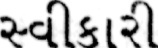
સ્વીકારી
